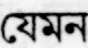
যেমন
